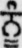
ਨੂੰ
